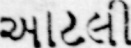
આટલી
